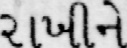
રાખીને
